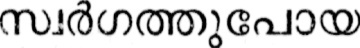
സ്വര്‍ഗത്തുപോയ
